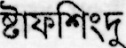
ষ্টাফশিংদু
